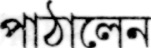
পাঠালেন
